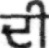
ਦੀ
